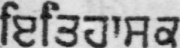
ਇਤਿਹਾਸਕ
